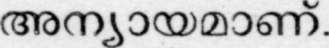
അന്യായമാണ്.
